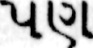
પણ
